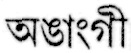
অঙাংগী
